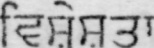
ਵਿਸ਼ੇਸ਼ਤਾ
